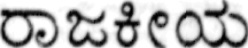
ರಾಜಕೀಯ
